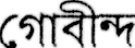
গোবীন্দ
